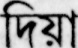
দিয়া
